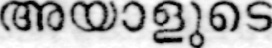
അയാളുടെ
